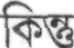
কিন্তু
